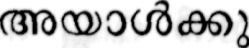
അയാള്‍ക്കു
